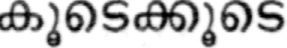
കൂടെക്കൂടെ
